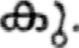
കു.
